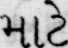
માટે
